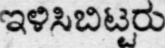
ಇಳಿಸಿಬಿಟ್ಟರು
